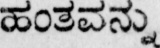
ಹಂತವನ್ನು
